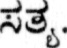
ಸತ್ಯ.
